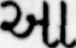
આ
